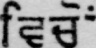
ਵਿਚੋਂ
